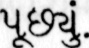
પૂછ્યું.
